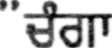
''ਚੰਗਾ
